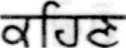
ਕਹਿਣ
